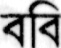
ববি
